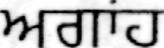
ਅਗਾਂਹ
